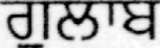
ਗੁਲਾਬ
